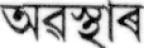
অৱস্থাৰ
